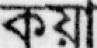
কয়া
